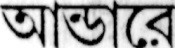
আন্ডারে
